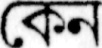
কেন
